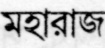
মহারাজ
